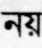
নয়
